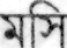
মসি
